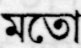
মতো
